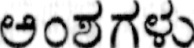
ಅಂಶಗಳು
